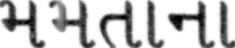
મમતાના
